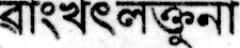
ৱাংখৎলক্তুনা
